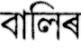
বালিৰ
